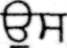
ਉਸ
